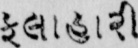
ફલાહારી
